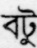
বটু
